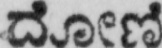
ದೋಣಿ
